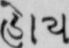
હોય
